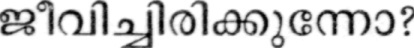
ജീവിച്ചിരിക്കുന്നോ?
